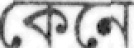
কেনে
